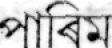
পাৰিম
